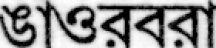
ঙাওরবরা
